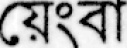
য়েংবা
